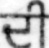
ਦੀ
